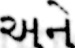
અને
